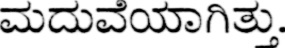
ಮದುವೆಯಾಗಿತ್ತು.
